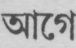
আগে
